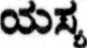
ಯಸ್ಯ
